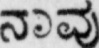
ನಾವು
